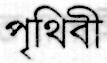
পৃথিবী
